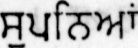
ਸੁਪਨਿਆਂ
